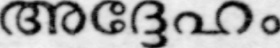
അദ്ദേഹം
